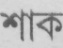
শাক
